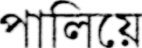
পালিয়ে
